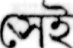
সেই
